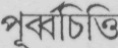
পূৰ্ব্বচিত্তি
